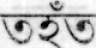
তহঁত
